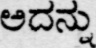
ಅದನ್ನು
